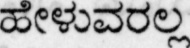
ಹೇಳುವರಲ್ಲ
